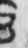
ਤੇ
